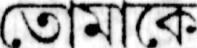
তোমাকে
